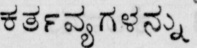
ಕರ್ತವ್ಯಗಳನ್ನು
